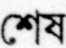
শেষ
